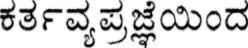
ಕರ್ತವ್ಯಪ್ರಜ್ಞೆಯಿಂದ
